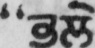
''ਭਲੇ
